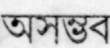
অসম্ভব
